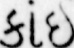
કાંઈ
